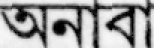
অনাবা
